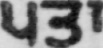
ਪਤਾ
